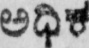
ಅಧಿಕ
